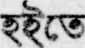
হইতে
